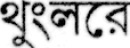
থুংলরে
